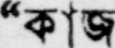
‘‘কাজ
